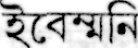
ইবেম্মনি
